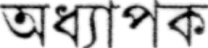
অধ্যাপক
